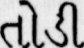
તોડી
